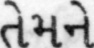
તેમને
